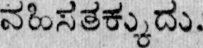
ವಹಿಸತಕ್ಕುದು.
